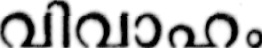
വിവാഹം
